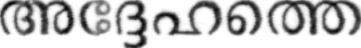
അദ്ദേഹത്തെ
